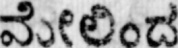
ಮೇಲಿಂದ
